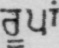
ਰੂਪਾਂ
